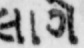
લાગે
